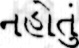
નહોતું
